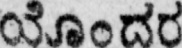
ಯೊಂದರ
